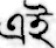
এই
